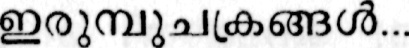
ഇരുമ്പുചക്രങ്ങള്‍...
